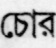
চোর
